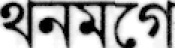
থনমগে
